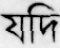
যদি
